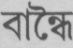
বান্ধৈ
